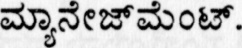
ಮ್ಯಾನೇಜ್‌ಮೆಂಟ್.
